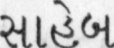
સાહેબ
